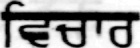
ਵਿਚਾਰ
